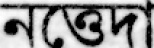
নত্তেদা
